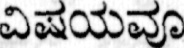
ವಿಷಯವೂ
